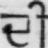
ਦੀ
